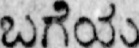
ಬಗೆಯ
